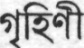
গৃহিণী
